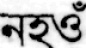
নহওঁ
